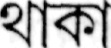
থাকা
